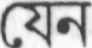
যেন
